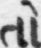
તો
